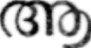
ആ
